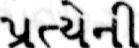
પ્રત્યેની
